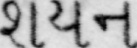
શયન
